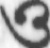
ও
